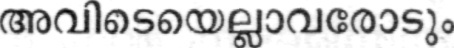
അവിടെയെല്ലാവരോടും
